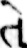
તે
